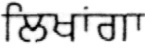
ਲਿਖਾਂਗਾ
